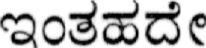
ಇಂತಹದೇ
